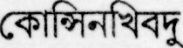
কোন্সিনখিবদু
